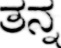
ತನ್ನ
